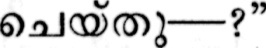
ചെയ്തു-?”
